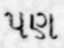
પણ
